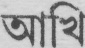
আখি
